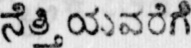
ನೆತ್ತಿಯವರೆಗೆ
